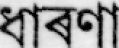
ধাৰণা
